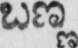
ಬಣ್ಣ
